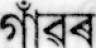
গাঁৱৰ
